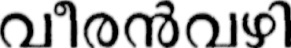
വീരന്‍വഴി
